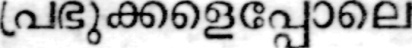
പ്രഭുക്കളെപ്പോലെ
